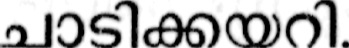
ചാടിക്കയറി.
